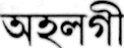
অহলগী
